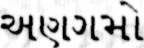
અણગમો
